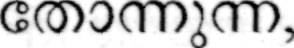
തോന്നുന്ന,
